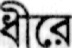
ধীরে
